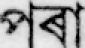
পৰা
